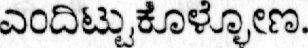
ಎಂದಿಟ್ಟುಕೊಳ್ಳೋಣ.
